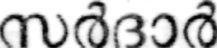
സര്‍ദാര്‍
